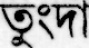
তুংদা
